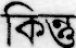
কিন্তু
